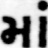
માં
